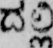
ದಲ್ಲಿ
